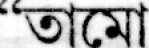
“তামো
